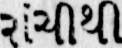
રાંચીથી
